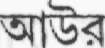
আউর
